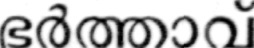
ഭര്‍ത്താവ്
